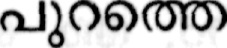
പുറത്തെ
